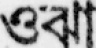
ওঝা
